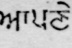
ਆਪਣੇ
